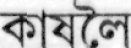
কাষলৈ
